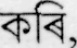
কৰি,
